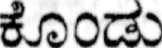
ಕೊಂಡು
